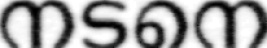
നടനെ
